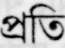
প্রতি
